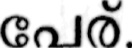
പേര്.
